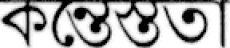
কন্তেস্ততা
